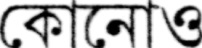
কোনোও
